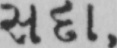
સદા,
